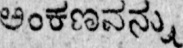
ಅಂಕಣವನ್ನು
